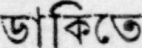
ডাকিতে
